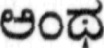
ಅಂಥ
